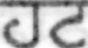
ਹਟ
